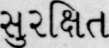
સુરક્ષિત
